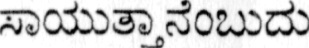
ಸಾಯುತ್ತಾನೆಂಬುದು
